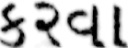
કરવા
